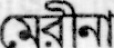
মেরীনা
